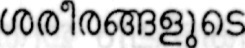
ശരീരങ്ങളുടെ
